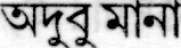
অদুবু
